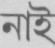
নাই
